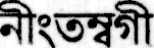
নীংতম্বগী
